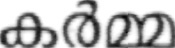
കര്‍മ്മ
